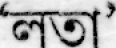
'লতা'
